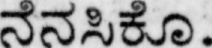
ನೆನಸಿಕೊ.
